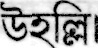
উহল্লি।
